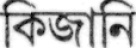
কিজানি
